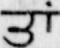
ਤਾਂ
